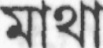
মাথা
